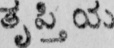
ತೃಪ್ತಿಯ
